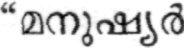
“മനുഷ്യര്‍
